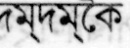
দম্‌দম্‌কৈ
